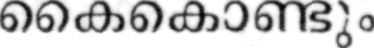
കൈകൊണ്ടും
